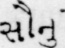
સૌનું
